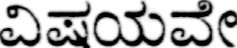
ವಿಷಯವೇ
